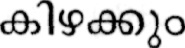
കിഴക്കും
